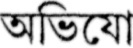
অভিযো
